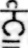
ਨੂੰ
